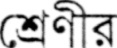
শ্রেণীর
